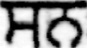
ਸਨ
